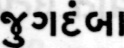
જુગદંબા
